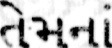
તેમનાં
